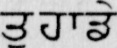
ਤੁਹਾਡੇ
